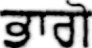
ਭਾਗੋ
